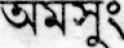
অমসুং
